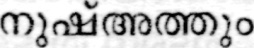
നുഷ്അത്തും
